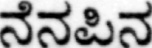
ನೆನಪಿನ
